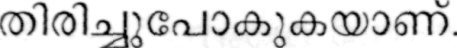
തിരിച്ചുപോകുകയാണ്.
